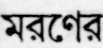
মরণের
